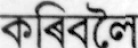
কৰিবলৈ
